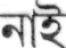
নাই
